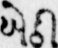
બેઠી
